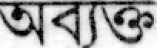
অব্যক্ত
